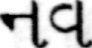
નવ
